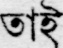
তাই
